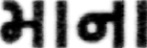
માના
